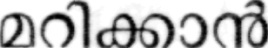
മറിക്കാന്‍
